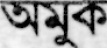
অমুক
